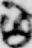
છે
